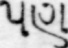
પણ
